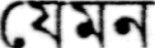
যেমন
